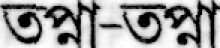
তপ্না-তপ্না
